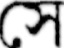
সে
